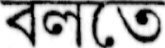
বলতে
